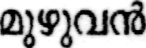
മുഴുവന്‍
